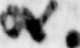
જ.
